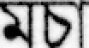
মচা
